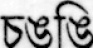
চঙঙি
